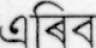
এৰিব
